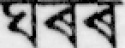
ঘৰৰ
